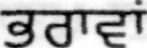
ਭਰਾਵਾਂ
